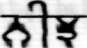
ਨੀਝ
